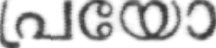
പ്രയോ
